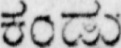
ಕಂಡು
